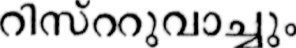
റിസ്ററുവാച്ചും
